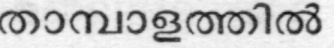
താമ്പാളത്തില്‍
